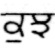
ਕੁਝ
